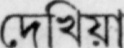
দেখিয়া
